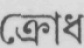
ক্ৰোধ
